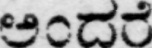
ಅಂದರೆ
